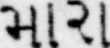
મારા
